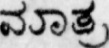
ಮಾತ್ರ
